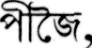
পীজৈ,
